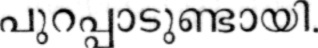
പുറപ്പാടുണ്ടായി.
